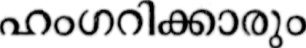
ഹംഗറിക്കാരും
